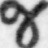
જ
